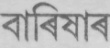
বাৰিষাৰ
